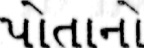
પોતાનો
